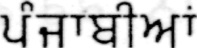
ਪੰਜਾਬੀਆਂ
